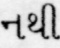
નથી
